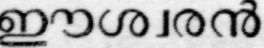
ഈശ്വരന്‍
